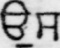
ਉਸ
